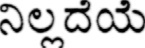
ನಿಲ್ಲದೆಯೆ
